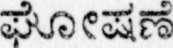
ಘೋಷಣೆ
